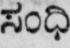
ಸಂಧಿ
